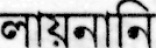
লায়নানি
